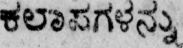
ಕಲಾಪಗಳನ್ನು
